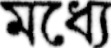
মধ্যে
